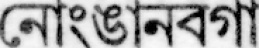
নোংঙানবগা
